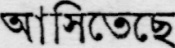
আসিতেছে
